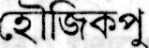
হৌজিকপু
